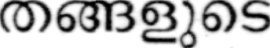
തങ്ങളുടെ
